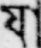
যা
